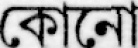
কোনো
